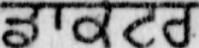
ਡਾਕਟਰ
